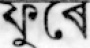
ফুৰে
